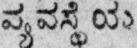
ವ್ಯವಸ್ಥೆಯ
